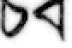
চব
